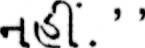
નહીં."
